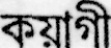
কয়াগী
